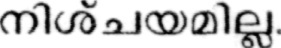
നിശ്ചയമില്ല.
